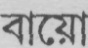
বায়ো
